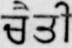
ਚੈਤੀ
